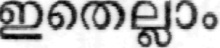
ഇതെല്ലാം
